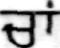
ਚਾਂ
